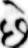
છે
